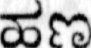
ಹಣ
